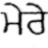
ਮੇਰੇ
